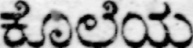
ಕೊಲೆಯ
